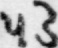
પડે
